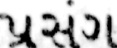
પ્રસંગ
